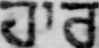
ਹਾਰ
